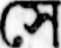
সে
